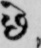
છે.
